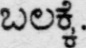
ಬಲಕ್ಕೆ.
